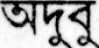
অদুবু
